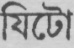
যিটো
